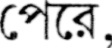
পেরে,
